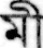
মী
